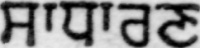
ਸਾਧਾਰਣ
